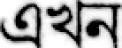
এখন
